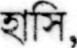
হাসি,
